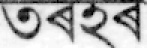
তৰহৰ
